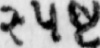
સ્પષ્ટ
